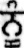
ਨੂੰ
